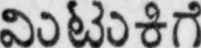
ಮಿಟುಕಿಗೆ
